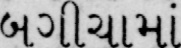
બગીચામાં
